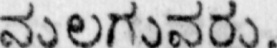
ಮಲಗುವರು.
